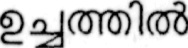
ഉച്ചത്തില്‍
